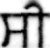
ਸੀ
